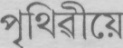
পৃথিৱীয়ে
